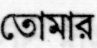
তোমার
